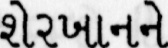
શેરખાનને
